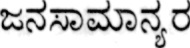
ಜನಸಾಮಾನ್ಯರ
